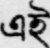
এই
